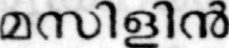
മസിളിന്‍
